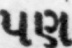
પણ
